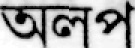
অলপ
